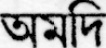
অমদি
